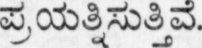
ಪ್ರಯತ್ನಿಸುತ್ತಿವೆ.
